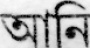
আনি
